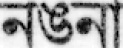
নঙনা
